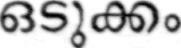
ഒടുക്കം
